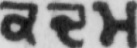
ਕਦਮ
